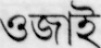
ওজাই
